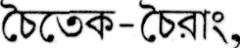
চৈতেক-চৈরাং,
